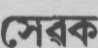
সেৱক
